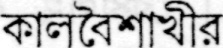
কালবৈশাখীর
